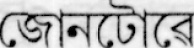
জোনটোৱে
